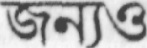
জন্যও
